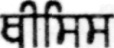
ਥੀਸਿਸ
